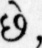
છે,
